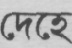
দেহে
